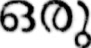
ഒരു
